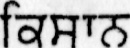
ਕਿਸਾਨ
